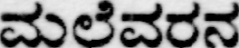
ಮಲೆವರನ
